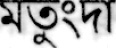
মতুংদা
